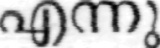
എന്നു
